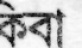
কিবা
